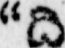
“ದಿ
